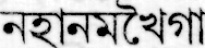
নহানমখৈগা
